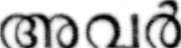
അവര്‍
